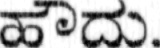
ಹೌದು.
